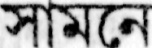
সামনে
